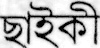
ছাইকী
